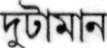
দুটামান
